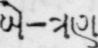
બે-ત્રણ
